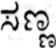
ಸಣ್ಣ
